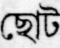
ছোট
